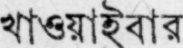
খাওয়াইবার
